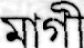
মাগী
